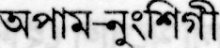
অপাম-নুংশিগী
